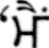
'ਮੈਂ
